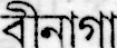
বীনাগা
